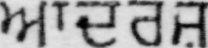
ਆਦਰਸ਼
